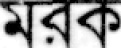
মরক
